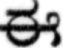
ಈ
